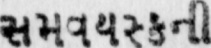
સમવયસ્કની
